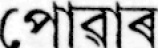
পোৱাৰ
